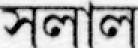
সলাল
